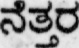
ನೆತ್ತರ
